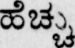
ಹೆಚ್ಚು
